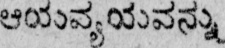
ಆಯವ್ಯಯವನ್ನು
